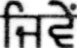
ਜਿਵੇਂ
